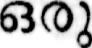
ഒരു
